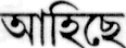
আহিছে
